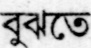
বুঝতে
